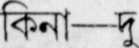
কিনা-দু
